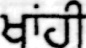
ਖਾਂਹੀ
